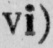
vi)
